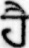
ਹੈ
